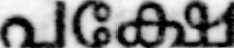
പക്ഷേ
